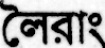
লৈরাং
